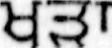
ਖੜਾ
